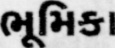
ભૂમિકા
